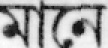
মানে
